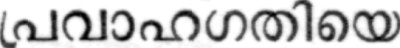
പ്രവാഹഗതിയെ
